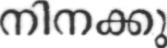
നിനക്കു
